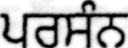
ਪਰਸੰਨ
